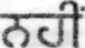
ਨਹੀਂ
